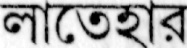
লাতেহার
